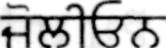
ਜੋਲੀਓਨ
